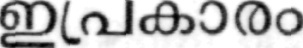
ഇപ്രകാരം
